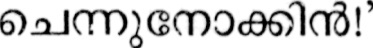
ചെന്നുനോക്കിന്‍!'
